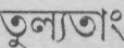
তুল্যতাং
